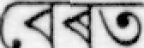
বেৰত
